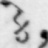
કે,
